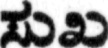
ಸುಖ
